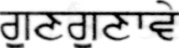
ਗੁਣਗੁਣਾਵੇ
